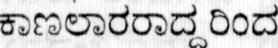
ಕಾಣಲಾರರಾದ್ದರಿಂದ
